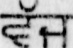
ਵੱਜ
